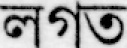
লগত
